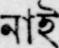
নাই
